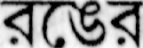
রঙের
